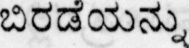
ಬಿರಡೆಯನ್ನು
